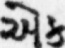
એક
